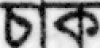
চাক
